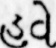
હવે
